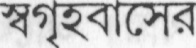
স্বগৃহবাসের
